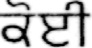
ਕੋਈ
